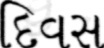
દિવસ
